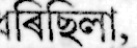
ধৰিছিলা,
